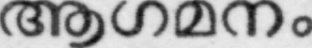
ആഗമനം
